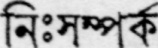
নিঃসম্পর্ক
